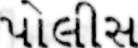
પોલીસ
